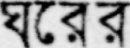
ঘরের
